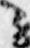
કે
